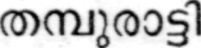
തമ്പുരാട്ടി
